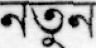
নতুন
